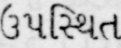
ઉપસ્થિત
